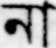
না
